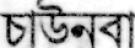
চাউনবা
